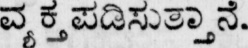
ವ್ಯಕ್ತಪಡಿಸುತ್ತಾನೆ.
